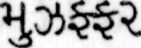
મુઝફ્ફર
